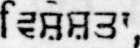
ਵਿਸ਼ੇਸ਼ਤਾ,
